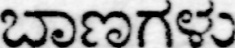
ಬಾಣಗಳು
